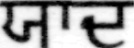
ਯਾਦ
